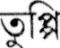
তুপ্পি
